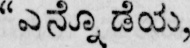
“ಎನ್ನೊಡೆಯ,
